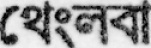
থেংলবা
